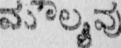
ಮೌಲ್ಯವು
